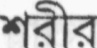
শরীর
